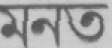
মনত
